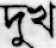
দুখ
